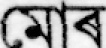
মোৰ
